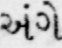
અંગે
